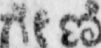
ಗೇಣಿ
